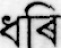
ধৰি
